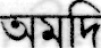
অমদি
